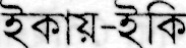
ইকায়-ইকি
